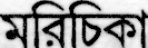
মরিচিকা
